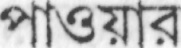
পাওয়ার
